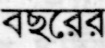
বছরের
